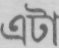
এটা
